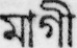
মাগী
